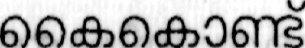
കൈകൊണ്ട്
